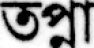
তপ্না
